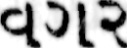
વગર
